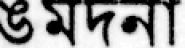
ঙমদনা
